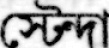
স্টেন্দা
